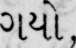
ગયો,
